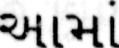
આમાં
